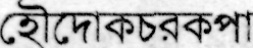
হৌদোকচরকপা
